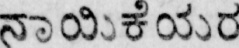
ನಾಯಿಕೆಯರ
